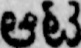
ಆಟ
